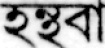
হন্থবা
